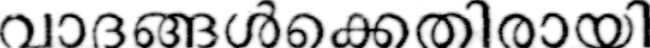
വാദങ്ങള്‍ക്കെതിരായി
